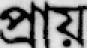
প্রায়
